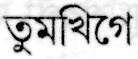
তুমখিগে
